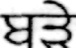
ਬੜੇ
